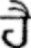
ਹੈ
